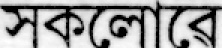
সকলোৱে
